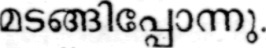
മടങ്ങിപ്പോന്നു.
